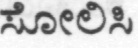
ಸೋಲಿಸಿ
